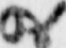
જ
